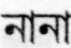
নানা
